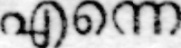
എന്നെ
